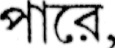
পারে,
